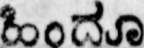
ಹಿಂದೂ
